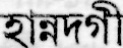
হান্নদগী
